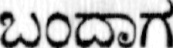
ಬಂದಾಗ
